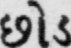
છોડ
